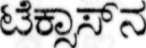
ಟೆಕ್ಸಾಸ್‌ನ
